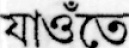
যাওঁতে
